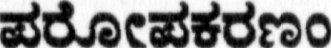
ಪರೋಪಕರಣ೦
